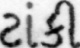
ટાંકી
